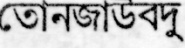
তোনজাউবদু
